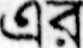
এর
